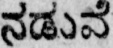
ನಡುವೆ
